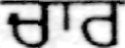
ਚਾਰ
